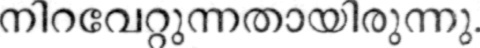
നിറവേറ്റുന്നതായിരുന്നു.
